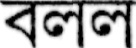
বলল
